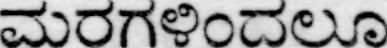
ಮರಗಳಿಂದಲೂ
